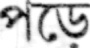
পড়ে
